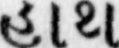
હાથ
